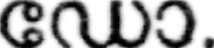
ഡോ.
